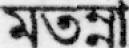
মতম্না
